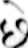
છે
